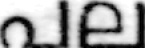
പല
